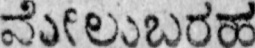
ಮೇಲುಬರಹ
